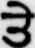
ਤੇ
